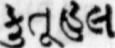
કુતૂહલ
